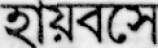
হায়বসে
